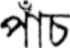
পাঁচ
